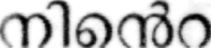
നിന്റെ
